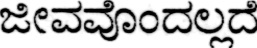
ಜೀವವೊಂದಲ್ಲದೆ
